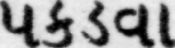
પકડવા
